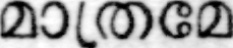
മാത്രമേ
